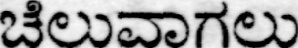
ಚೆಲುವಾಗಲು
